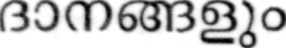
ദാനങ്ങളും
